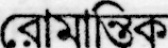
রোমন্তিক
